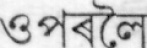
ওপৰলৈ
